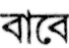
বাবে
